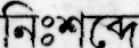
নিঃশব্দে
